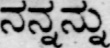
ನನ್ನನ್ನು
